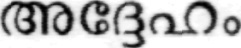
അദ്ദേഹം
